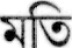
মতি
